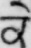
ਕੇ
